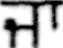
ਜਾ
